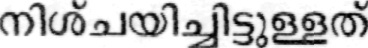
നിശ്ചയിച്ചിട്ടുള്ളത്
